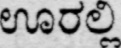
ಊರಲ್ಲಿ
